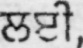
ਲਈ,
